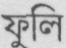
ফুলি
